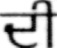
ਦੀ
